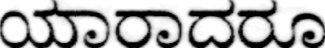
ಯಾರಾದರೂ
